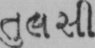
તુલસી
